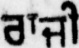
ਰਾਜੀ
